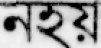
নহয়
